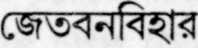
জেতবনবিহার
